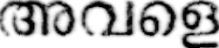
അവളെ
